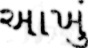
આખું
